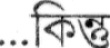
...কিন্তু
